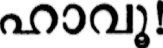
ഹാവൂ!
